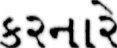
કરનારે
